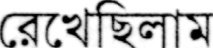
রেখেছিলাম
